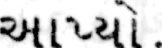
આપ્યો.
